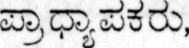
ಪ್ರಾಧ್ಯಾಪಕರು,
